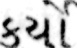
કર્યો
